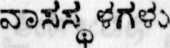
ವಾಸಸ್ಥಳಗಳು
